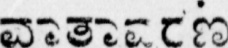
ವಾತಾವರಣ
